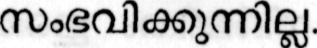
സംഭവിക്കുന്നില്ല.
